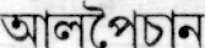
আলপৈচান
